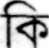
কি
